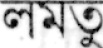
লমতু
